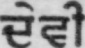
ਦੇਵੀ
